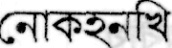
নোকহনখি
